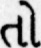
તો
